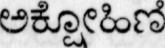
ಅಕ್ಷೋಹಿಣಿ
